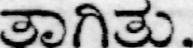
ತಾಗಿತು.
